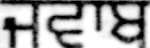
ਜਵਾਬ
